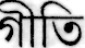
গীতি
